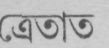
ত্ৰেতাত
